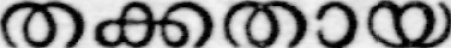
തക്കതായ
